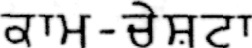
ਕਾਮ-ਚੇਸ਼ਟਾ
